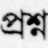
প্রশ্ন
